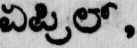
ಏಪ್ರಿಲ್,
